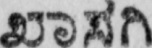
ಖಾಸಗಿ
